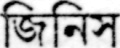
জিনিস
